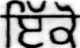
ਇੱਕੋ
